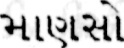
માણસો
